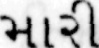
મારી
